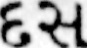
દસ
